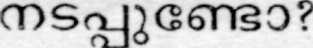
നടപ്പുണ്ടോ?
